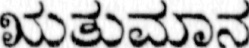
ಋತುಮಾನ
